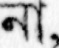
না,
